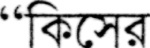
“কিসের
